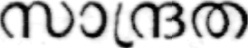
സാന്ദ്രത
